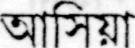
আসিয়া
